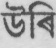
উৰি
